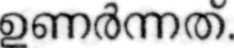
ഉണര്‍ന്നത്.
